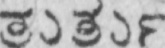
ತುರ್ತು
